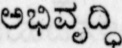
ಅಭಿವೃದ್ಧಿ
